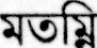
মতম্নি
